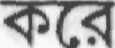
করে
